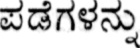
ಪಡೆಗಳನ್ನು
